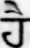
ਹੈ
